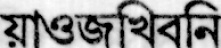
য়াওজখিবনি
